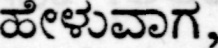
ಹೇಳುವಾಗ,
